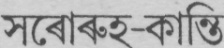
সৰোৰুহ-কান্তি
